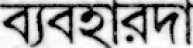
ব্যবহারদা
